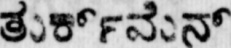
ತುರ್ಕ್ಮೆನ್
